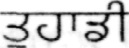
ਤੁਹਾਡੀ
